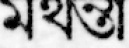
মথন্তা
